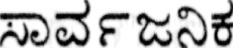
ಸಾರ್ವಜನಿಕ
